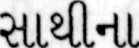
સાથીના
